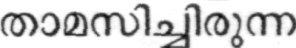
താമസിച്ചിരുന്ന
